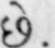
છે.
